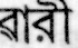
ৱারী
